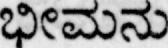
ಭೀಮನು
